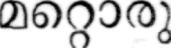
മറ്റൊരു
